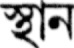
স্থান
